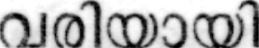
വരിയായി
